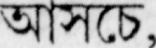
আসচে,
